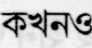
কখনও
